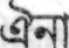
ঐনা
